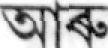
আৰু
